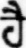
ਹੈ
